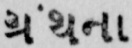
ગ્રંથના
